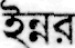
ইন্নর
